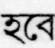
হবে
